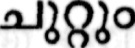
ചുറ്റും
